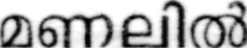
മണലില്‍
